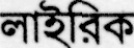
লাইরিক
